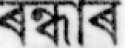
ৰন্ধাৰ
